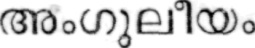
അംഗുലീയം
